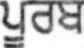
ਪੂਰਬ
